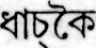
ধাচ্‌কৈ
